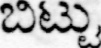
ಬಿಟ್ಟು
